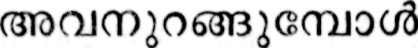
അവനുറങ്ങുമ്പോള്‍
